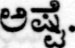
ಅಷ್ಟೆ.
